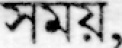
সময়,
